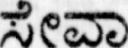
ಸೇವಾ
